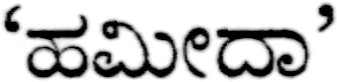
'ಹಮೀದಾ'
